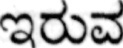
ಇರುವ
